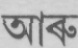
আৰু
